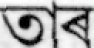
তাৰ
